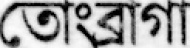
তোংব্রাগা
